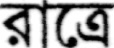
রাত্রে
